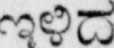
ಇಳಿದ
